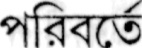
পরিবর্তে
